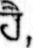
ਹੈ,
